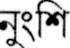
নুংশি
